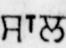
ਸਾਲ
